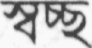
স্বচ্ছ
